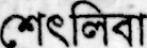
শেৎলিবা
